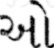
ઓ
